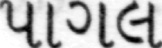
પાગલ
